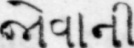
જોવાની
